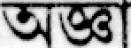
অজ্ঞা
